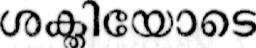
ശക്തിയോടെ
